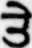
ਤੇ
